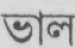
ভাল
